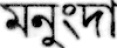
মনুংদা
